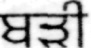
ਬੜੀ
